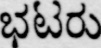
ಭಟರು
